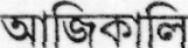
আজিকালি
